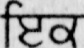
ਇਕ
